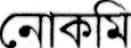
নোকমি
